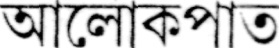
আলোকপাত
